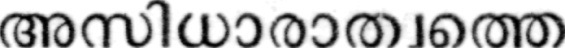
അസിധാരാത്വത്തെ
